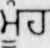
ਮੂੰਹ
